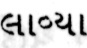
લાવ્યા
